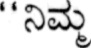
"ನಿಮ್ಮ
